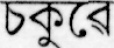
চকুৱে
